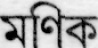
মণিক
